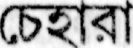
চেহারা
